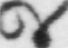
જ
